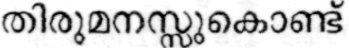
തിരുമനസ്സുകൊണ്ട്
